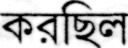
করছিল
